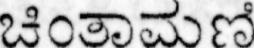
ಚಿಂತಾಮಣಿ
